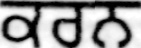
ਕਰਨ
